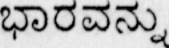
ಭಾರವನ್ನು
